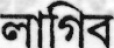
লাগিব
